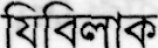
যিবিলাক
